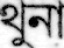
থুনা
